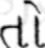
તો
